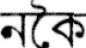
নকৈ
